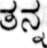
ತನ್ನ
